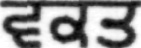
ਵਕਤ
